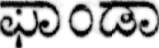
ಫಾಂಡಾ
